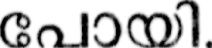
പോയി.
